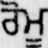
ਰੋਮੂ
